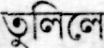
তুলিলে
